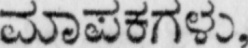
ಮಾಪಕಗಳು,
